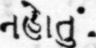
નહોતું.
